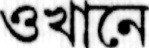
ওখানে
